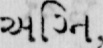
અગ્નિ,
